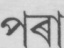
পৰা
